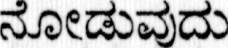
ನೋಡುವುದು
